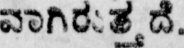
ವಾಗಿರುತ್ತದೆ.
